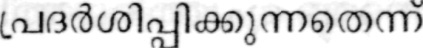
പ്രദര്‍ശിപ്പിക്കുന്നതെന്ന്
